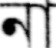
না
